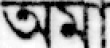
অমা
